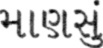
માણસું
